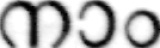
നാം
